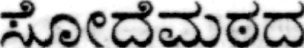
ಸೋದೆಮಠದ
